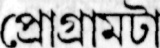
প্রোগ্রামটা
